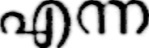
എന്ന
